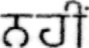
ਨਹੀਂ
